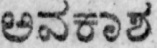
ಅವಕಾಶ
